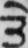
ਤੇ
